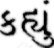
કહ્યું
